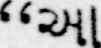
"આ
